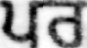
ਪਰ
